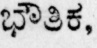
ಭೌತಿಕ,
